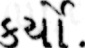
કર્યો.
